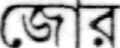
জোর
